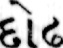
દોઢ
